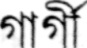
গার্গী
